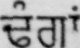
ਢੰਗਾਂ
